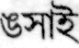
ঙসাই
